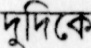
দুদিকে
